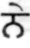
ਨੇ
